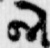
જો
